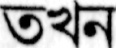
তখন
